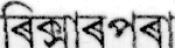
ৰিক্সাৰপৰা
